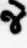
જે
